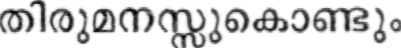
തിരുമനസ്സുകൊണ്ടും
